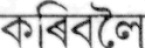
কৰিবলৈ
